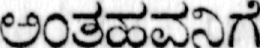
ಅಂತಹವನಿಗೆ
